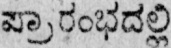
ಪ್ರಾರಂಭದಲ್ಲಿ
